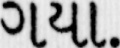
ગયા.
